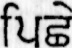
ਪਿਛੇ
